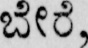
ಬೇರೆ,
